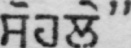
ਸੋਹਲੇ''
